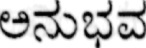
ಅನುಭವ
